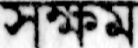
সক্ষম
